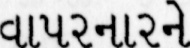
વાપરનારને
